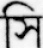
সি
